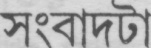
সংবাদটা
